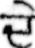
ਦੇ
